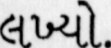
લખ્યો.
